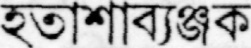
হতাশাব্যঞ্জক
